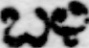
ಬಳಿ
